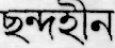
ছন্দহীন
